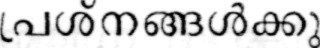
പ്രശ്നങ്ങള്‍ക്കു
